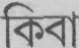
কিবা
